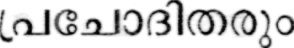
പ്രചോദിതരും
